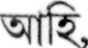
আহি,
